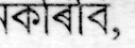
নকৰিবি,
